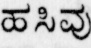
ಹಸಿವು
